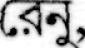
রেনু,
